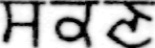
ਸਕਣ
